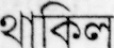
থাকিল
